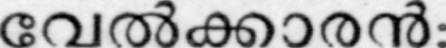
വേല്‍ക്കാരന്‍:
